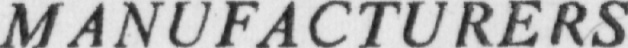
MANUFACTURERS
